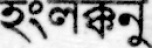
হংলক্কনু
